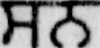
ਸਨ
